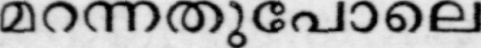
മറന്നതുപോലെ
